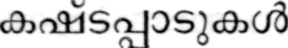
കഷ്ടപ്പാടുകള്‍
